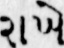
રાખે
